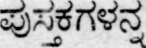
ಪುಸ್ತಕಗಳನ್ನ
